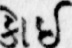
કોઈ
